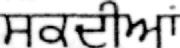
ਸਕਦੀਆਂ
